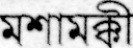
মশামক্কী
